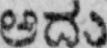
ಅದು
